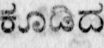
ಕೂಡಿದ
